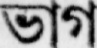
ভাগ
